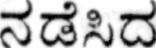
ನಡೆಸಿದ
